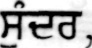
ਸੁੰਦਰ,
